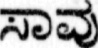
ಸಾವು
